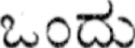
ಒಂದು
